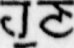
ਹੁਣ
